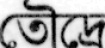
তৌদ্রে
